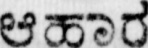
ಆಹಾರ
